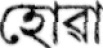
হোৱা
